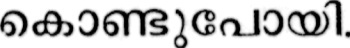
കൊണ്ടുപോയി.
